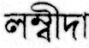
লম্বীদা
